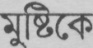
মুষ্টিকে
